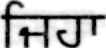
ਜਿਹਾ
